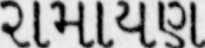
રામાયણ
